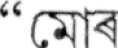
"মোৰ
